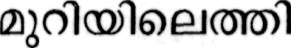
മുറിയിലെത്തി
